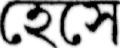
হেসে
